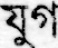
যুগ
